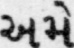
અમે
